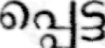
പ്പെട്ട
